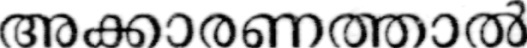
അക്കാരണത്താല്‍
